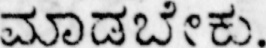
ಮಾಡಬೇಕು.
